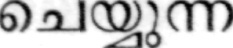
ചെയ്യുന്ന
